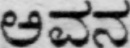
ಅವನ
